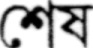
শেষ
